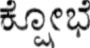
ಕ್ಷೋಭೆ
